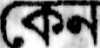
কেন
